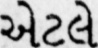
એટલે
